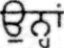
ਉਨ੍ਹਾਂ
